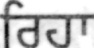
ਰਿਹਾ
